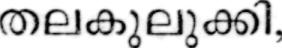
തലകുലുക്കി,
